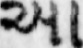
આ
